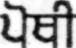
ਪੋਥੀ
